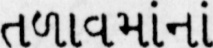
તળાવમાંનાં
